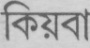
কিয়বা
